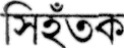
সিহঁতক
